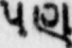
પણ
